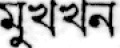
মুখখন
